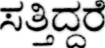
ಸತ್ತಿದ್ದರೆ
